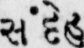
સંદેહ
